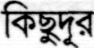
কিছুদূর
